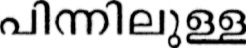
പിന്നിലുള്ള
